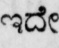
ಇದೇ
